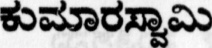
ಕುಮಾರಸ್ವಾಮಿ
